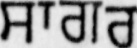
ਸਾਗਰ
